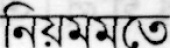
নিয়মমতে
